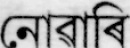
নোৱাৰি
